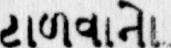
ટાળવાનો
